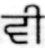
ਵੀ
